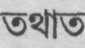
তথাত
